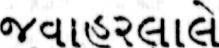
જવાહરલાલે
